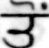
ਤੋਂ
